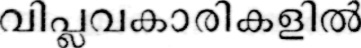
വിപ്ലവകാരികളില്‍
